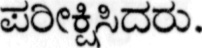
ಪರೀಕ್ಷಿಸಿದರು.
